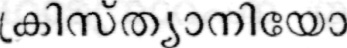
ക്രിസ്ത്യാനിയോ
